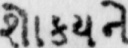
શોક્યને
